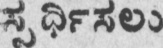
ಸ್ಪರ್ಧಿಸಲು
